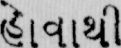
હોવાથી
